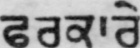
ਫਰਕਾਰੇ
